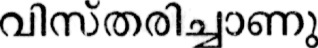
വിസ്തരിച്ചാണു
